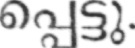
പ്പെട്ടു.
